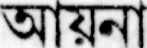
আয়না
